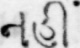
નહીં
